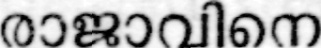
രാജാവിനെ
